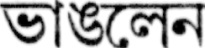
ভাঙলেন
